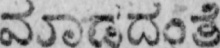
ಮಾಡದಂತೆ
